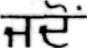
ਜਦੋਂ
